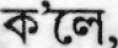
ক'লে,
